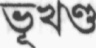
ভূখণ্ড
